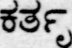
ಕರ್ತೃ
